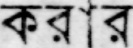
করার
